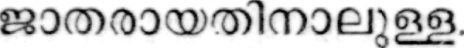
ജാതരായതിനാലുള്ള.
